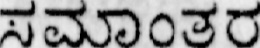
ಸಮಾಂತರ
